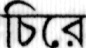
চিরে
